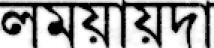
লময়ায়দা
